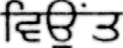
ਵਿਉਂਤ
